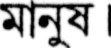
মানুষ।
